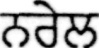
ਨਰੇਲ
